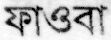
ফাওবা
